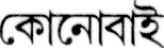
কোনোবাই
